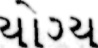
યોગ્ય
